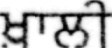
ਖ਼ਾਲੀ
